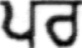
ਪਰ
